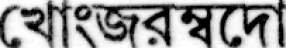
খোংজরম্বদো
